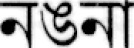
নঙনা
